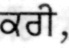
ਕਰੀ,
